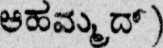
ಅಹಮ್ಮದ್)
